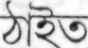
ঠাইত
